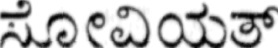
ಸೋವಿಯತ್
